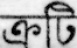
ক্রটি
